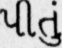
પીતું
